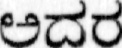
ಅದರ
